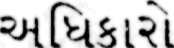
અધિકારો
